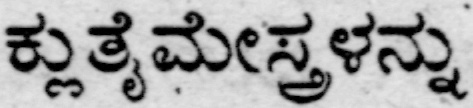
ಕ್ಣುತೈಮೇಸ್ತ್ರಳನ್ನು
